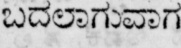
ಬದಲಾಗುವಾಗ
